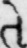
તે
